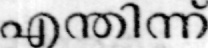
എന്തിന്ന്
